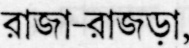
রাজা-রাজড়া,
